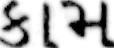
કામ
